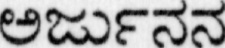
ಅರ್ಜುನನ
